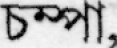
চম্পা,
